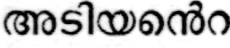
അടിയന്റെ
